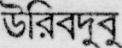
উরিবদুবু
